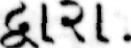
દ્વારા.
